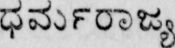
ಧರ್ಮರಾಜ್ಯ
